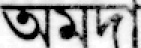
অমদা
